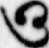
ও
